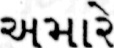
અમારે
